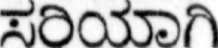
ಸರಿಯಾಗಿ
